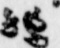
કહું
